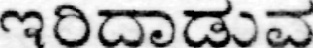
ಇರಿದಾಡುವ
